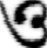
ও
